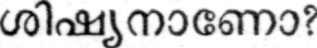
ശിഷ്യനാണോ?
